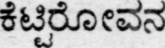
ಕೆಟ್ಟಿರೋವನ
